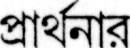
প্রার্থনার
